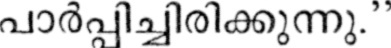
പാര്‍പ്പിച്ചിരിക്കുന്നു."
